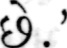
છે.'
